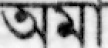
অমা
